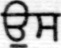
ਉਸ
